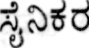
ಸೈನಿಕರ
